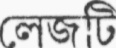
লেজটি
